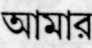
আমার
